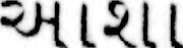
આશા
